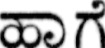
ಹಾಗೆ
